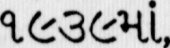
૧૯૩૯માં,
